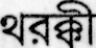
থরক্কী
